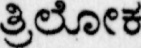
ತ್ರಿಲೋಕ
